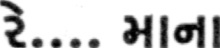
રે...માના
